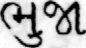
ભુજા
